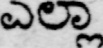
ಎಲ್ಲಾ
